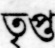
তৃপ্ত
